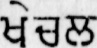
ਖੇਚਲ
